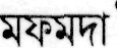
মফমদা
